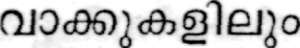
വാക്കുകളിലും
